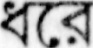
ধরে
